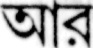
আর
